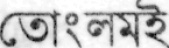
তোংলমই
